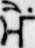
ਮੈਂ
